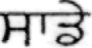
ਸਾਡੇ
